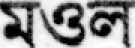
মওল
